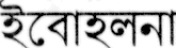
ইবোহলনা
